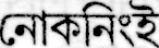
নোকনিংই
